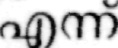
എന്ന്
